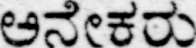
ಅನೇಕರು
